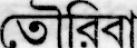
তৌরিবা
